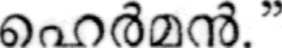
ഹെര്‍മന്‍."
